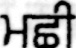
ਮਛੀ
